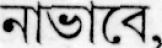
নাভাবে,
